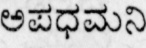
ಅಪಧಮನಿ
